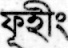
ফূহীং
